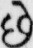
છે
